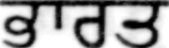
ਭਾਰਤ
